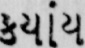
ક્યાંય
